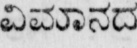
ವಿಮಾನದ
